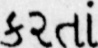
કરતાં
